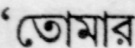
‘তোমার
